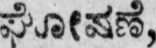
ಘೋಷಣೆ,
